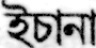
ইচানা
